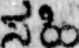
ಸಹಿ
